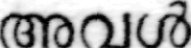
അവള്‍
